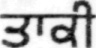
ਤਾਕੀ
